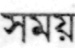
সময়
